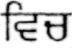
ਵਿਚ
